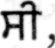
ਸੀ,
